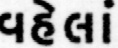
વહેલાં
